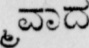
ವಾದ
